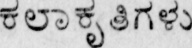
ಕಲಾಕೃತಿಗಳು
